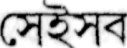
সেইসব
